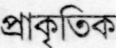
প্রাকৃতিক
